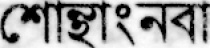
শোন্থাংনবা
